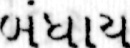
બંધાય
